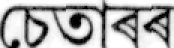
চেতাৰৰ
